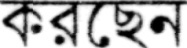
করছেন
